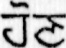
ਹੋਣ
